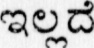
ಇಲ್ಲದೆ
